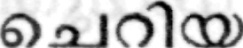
ചെറിയ
